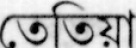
তেতিয়া
